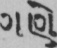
ગણે
